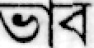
ভাব
